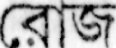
রোজ
